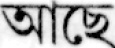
আছে
